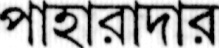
পাহারাদার
